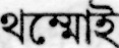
থম্মোই
